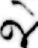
જે
